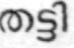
തട്ടി
